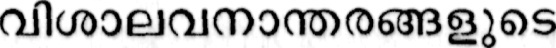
വിശാലവനാന്തരങ്ങളുടെ
